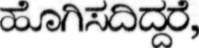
ಹೊಗಿಸದಿದ್ದರೆ,
